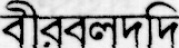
বীরবলদদি
